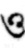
ও
